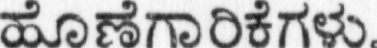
ಹೊಣೆಗಾರಿಕೆಗಳು.
